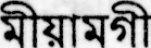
মীয়ামগী
